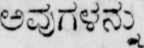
ಅವುಗಳನ್ನು
